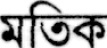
মতিক
